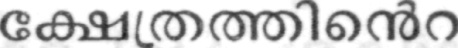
ക്ഷേത്രത്തിന്റെ
